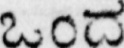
ಒಂದ
